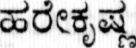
ಹರೇಕೃಷ್ಣ
